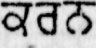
ਕਰਨ
